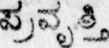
ಪ್ರವೃತ್ತಿ
